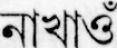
নাখাওঁ
